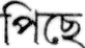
পিছে
